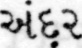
અંદર
